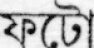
ফটো
